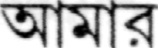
আমার
